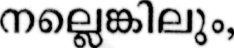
നല്ലെങ്കിലും,
